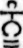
ਨੂੰ
